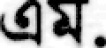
এম.
